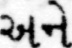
અને
